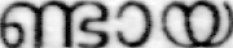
ണ്ടായ
